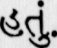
હતું.
